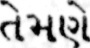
તેમણે
